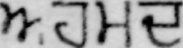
ਅਹਮਦ
